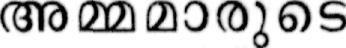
അമ്മമാരുടെ
